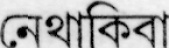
নেথাকিবা
